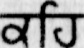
ਕਹਿ
